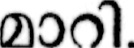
മാറി.
